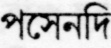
পসেনদি
